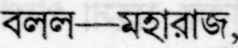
বলল–মহারাজ,
